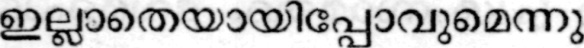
ഇല്ലാതെയായിപ്പോവുമെന്നു
